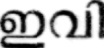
ഇവി
